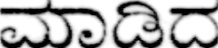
ಮಾಡಿದ
